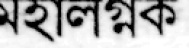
মহালগ্নক
